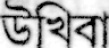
উখিবা
